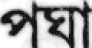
পঘা
